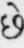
છે
